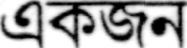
একজন
